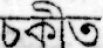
চকীত
